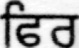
ਫਿਰ
